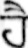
ਹੈ
